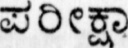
ಪರೀಕ್ಷಾ
